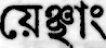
য়েঞ্ছাং
